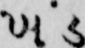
ખંડ
